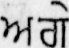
ਅਗੇ
